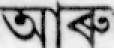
আৰু
